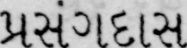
પ્રસંગદાસ
